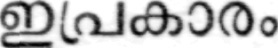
ഇപ്രകാരം
